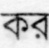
কর
